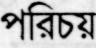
পরিচয়
